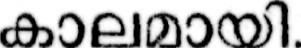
കാലമായി.
